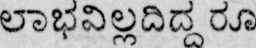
ಲಾಭವಿಲ್ಲದಿದ್ದರೂ
